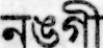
নঙগী
